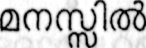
മനസ്സില്‍
